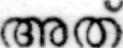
അത്
